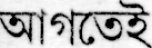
আগতেই
